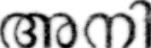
അനി
